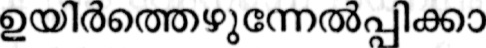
ഉയിര്‍ത്തെഴുന്നേല്‍പ്പിക്കാ
